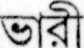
ভারী
